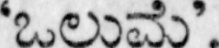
‘ಒಲುಮೆ’.
